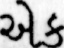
એક
